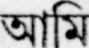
আমি
